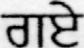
ਗਏ
